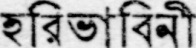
হরিভাবিনী
